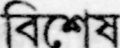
বিশেষ
